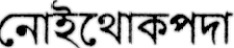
নোইথোকপদা
